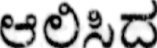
ಆಲಿಸಿದ
